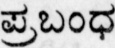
ಪ್ರಬಂಧ
